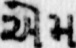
એમ
